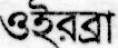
ওইরব্রা
